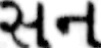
સન
